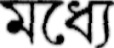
মধ্যে
